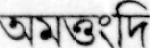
অমত্তংদি
